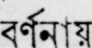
বর্ণনায়
